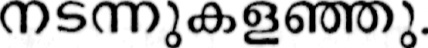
നടന്നുകളഞ്ഞു.
